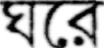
ঘরে
